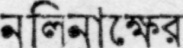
নলিনাক্ষের
